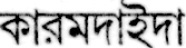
কারমদাইদা
